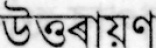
উত্তৰায়ণ
